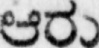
ಆರು
